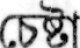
চেষ্টা
